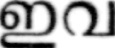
ഇവ
